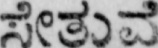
ಸೇತುವೆ
